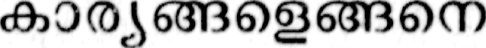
കാര്യങ്ങളെങ്ങനെ
